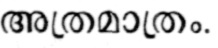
അത്രമാത്രം.
